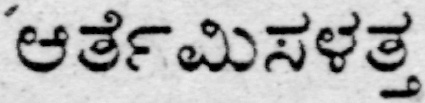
ಆರ್ತೆಮಿಸಳತ್ತ
